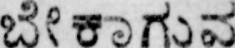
ಬೇಕಾಗುವ
